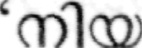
‘നിയ
